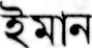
ইমান
